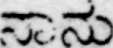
ನಾನು
